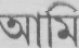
আমি
